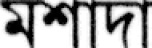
মশাদা
